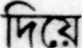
দিয়ে
